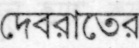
দেবরাতের
